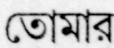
তোমার
